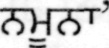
ਨਮੂਨਾ'
